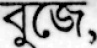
বুজে,
